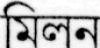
মিলন
